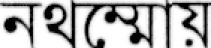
নথম্মোয়
